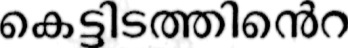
കെട്ടിടത്തിന്റെ
